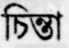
চিন্তা
